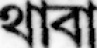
থাবা
